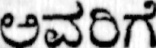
ಅವರಿಗೆ
